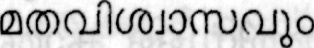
മതവിശ്വാസവും
